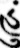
હું
